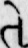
તે
